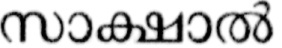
സാക്ഷാല്‍
